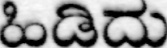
ಹಿಡಿದು
